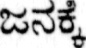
ಜನಕ್ಕೆ
